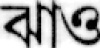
ঝাও
